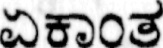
ಏಕಾಂತ
